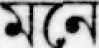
মনে
